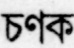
চণক
